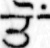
ਤੋਂ
